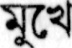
মুখে
